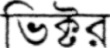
ভিক্টর
